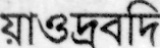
য়াওদ্রবদি
